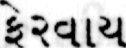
ફેરવાય
